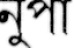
নুপা
